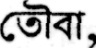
তৌবা,
